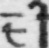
ਦੀ
